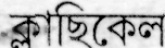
ক্লাছিকেল
